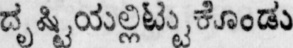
ದೃಷ್ಟಿಯಲ್ಲಿಟ್ಟುಕೊಂಡು
